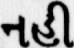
નહી
